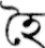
হৈ
